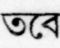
তবে
